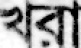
খরা
